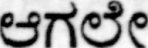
ಆಗಲೇ
